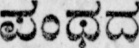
ಪಂಥದ
